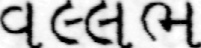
વલ્લભ
